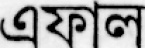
এফাল
